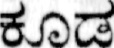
ಕೂಡ
